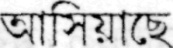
আসিয়াছে
